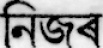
নিজৰ
